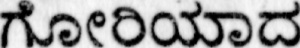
ಗೋರಿಯಾದ
